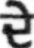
ਦੇ
